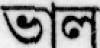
ভাল
